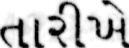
તારીખે
